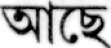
আছে
